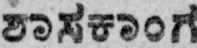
ಶಾಸಕಾಂಗ
